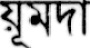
য়ূমদা
